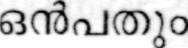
ഒന്‍പതും
